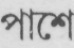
পাশে
